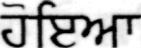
ਹੋਇਆ
